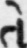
તે
